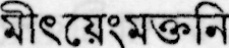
মীৎয়েংমক্তনি
